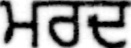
ਮਰਦ
